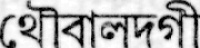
থৌবালদগী
